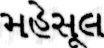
મહેસૂલ
